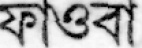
ফাওবা
